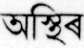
অস্থিৰ
